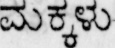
ಮಕ್ಕಳು
